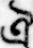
ঐ
